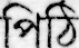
পিঠি
